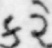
કરે
